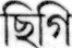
ছিগি
